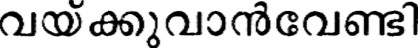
വയ്ക്കുവാന്‍വേണ്ടി
